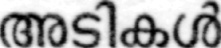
അടികള്‍
